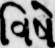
વિષે
